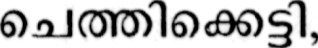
ചെത്തിക്കെട്ടി,
